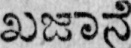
ಖಜಾನೆ
